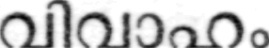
വിവാഹം
